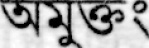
অমুক্তং
